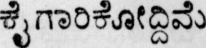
ಕೈಗಾರಿಕೋದ್ದಿಮೆ
